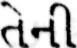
તેની
